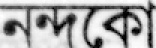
নন্দকো
